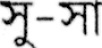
সু-সা
